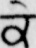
ਕੇ
